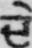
ਦੇ
